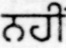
ਨਹੀਂ
